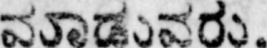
ಮಾಡುವರು.
